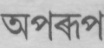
অপৰূপ
